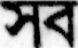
সব
